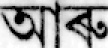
আৰু
